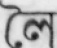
লৈ
